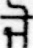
ਜੋ
